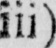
iii)
